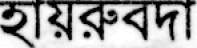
হায়রুবদা
